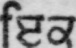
ਇਕ
